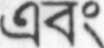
এবং
